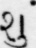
શું
